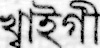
খ্বাইদগী
